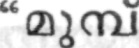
"മുമ്പ്
